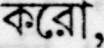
করো,
